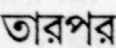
তারপর
